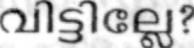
വിട്ടില്ലേ?
